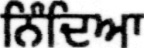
ਨਿੰਦਿਆ
